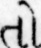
તો
